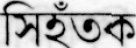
সিহঁতক
